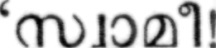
'സ്വാമീ!
